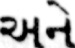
અને
